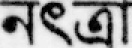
নৎত্রা
